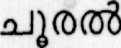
ചൂരല്‍
